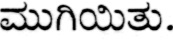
ಮುಗಿಯಿತು.
